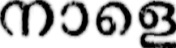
നാളെ
